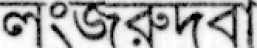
লংজরুদবা
